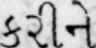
કરીને
